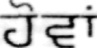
ਹੋਵਾਂ
